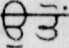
ਉਤੋਂ
